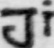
ਹਾਂ
